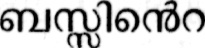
ബസ്സിന്റെ
